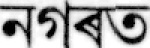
নগৰত
